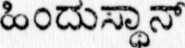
ಹಿಂದುಸ್ಥಾನ್
